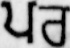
ਪਰ
